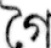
গৈ
